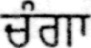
ਚੰਗਾ
